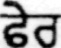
ਫੇਰ
